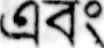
এবং
